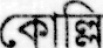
কোল্লি
